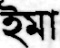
ইমা
